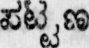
ಪಟ್ಟಣ
